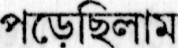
পড়েছিলাম
